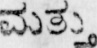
ಮತ್ತು
